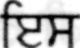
ਇਸ
